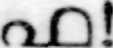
ഫ!
